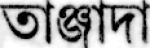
তাঞ্জাদা
